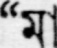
‘‘মা
